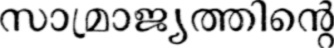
സാമ്രാജ്യത്തിന്റെ
